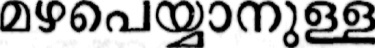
മഴപെയ്യാനുള്ള
